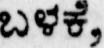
ಬಳಕೆ,
